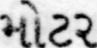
મોટર
